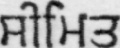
ਸੀਮਤ
